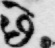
છે
